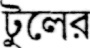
টুলের
